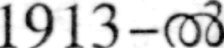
1913-ല്‍
